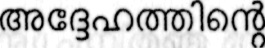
അദ്ദേഹത്തിന്റെ
